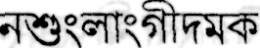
নশুংলাংগীদমক
